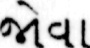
જોવા
